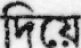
দিয়ে
